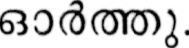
ഓര്‍ത്തു.
